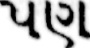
પણ
